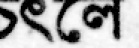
চৎলে
